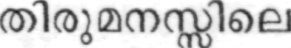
തിരുമനസ്സിലെ
